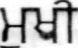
ਮੁਖੀ
